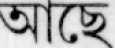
আছে
